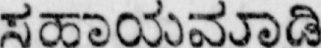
ಸಹಾಯಮಾಡಿ
